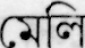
মেলি
